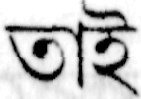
তাই
